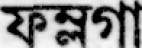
ফম্লগা
